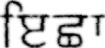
ਇਛਾ
